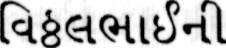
વિઠ્ઠલભાઈની
